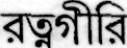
রত্নগীরি
